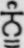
ਨੂੰ
